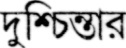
দুশ্চিন্তার
